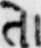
તો
